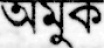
অমুক
